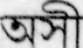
অসী
